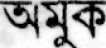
অমুক
